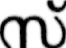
സ്
